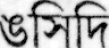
ঙসিদি
